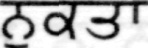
ਨੁਕਤਾ
